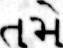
તમે
